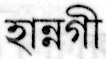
হান্নগী
